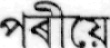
পৰীয়ে
